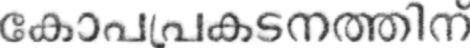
കോപപ്രകടനത്തിന്
